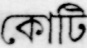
কোটি
